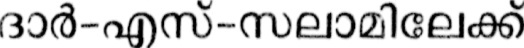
ദാര്‍-എസ്-സലാമിലേക്ക്
